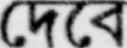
দেবে
